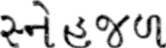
સ્નેહજળ
